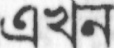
এখন
